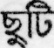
ছুটি
